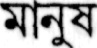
মানুষ
